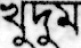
খুদুম
